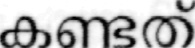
കണ്ടത്
